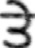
ਤੇ
